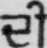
ਦੀ
